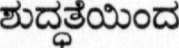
ಶುದ್ಧತೆಯಿಂದ
